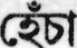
হেঁচা
